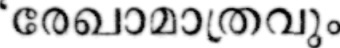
'രേഖാമാത്രവും
